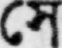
সে
